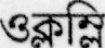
ওক্লম্লি
